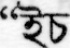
"ইচ
